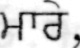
ਮਾਰੇ,
